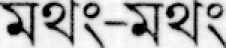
মথং-মথং
